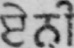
ਏਨੀ
